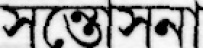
সন্তোসনা
